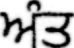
ਅੰਤ
